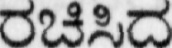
ರಚಿಸಿದ
